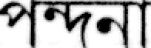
পন্দনা
